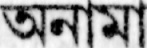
অনামা
